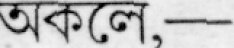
অকলে,-
